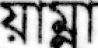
য়াম্না
